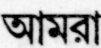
আমরা
